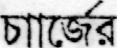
চার্জের
